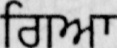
ਗਿਆ
